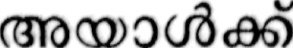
അയാള്‍ക്ക്
